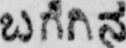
ಬಗೆಗಿನ
